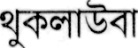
থুকলাউবা
